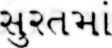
સુરતમાં
